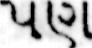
પણ
